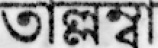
তাল্লম্বা
